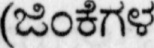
(ಜಿಂಕೆಗಳ
